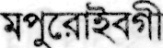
মপুরোইবগী
